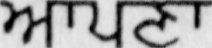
ਆਪਣਾ
